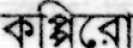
কপ্পিরো
